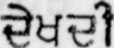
ਦੇਖਦੀ
